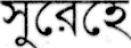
সুরেহে
